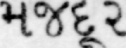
મજદૂર
